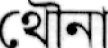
থৌনা
